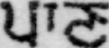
ਪਾਣ
